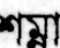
শম্না
